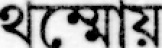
থম্মোয়
